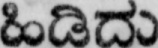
ಹಿಡಿದು
